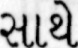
સાથે
